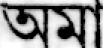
অমা
